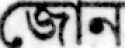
জোন
